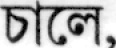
চালে,
